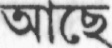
আছে
